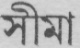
সীমা
